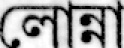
লোন্না
